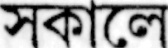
সকালে
